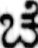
ಚೆ
